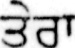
ਤੇਰਾ
